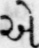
એ
